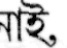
নাই,
